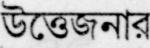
উত্তেজনার
